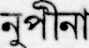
নুপীনা
